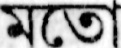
মতো
